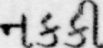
નકકી
